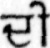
ਦੀ
